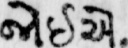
જોઈએ.
